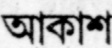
আকাশ
